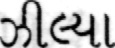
ઝીલ્યા
